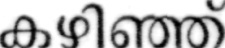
കഴിഞ്ഞ്
